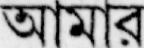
আমার
